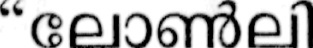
“ലോണ്‍ലി
